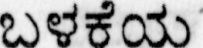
ಬಳಕೆಯ
